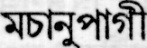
মচানুপাগী
